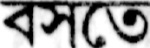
বসতে
